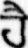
ਹੈ
